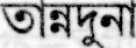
তান্নদুনা
